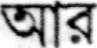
আর
